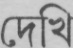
দেখি
